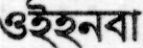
ওইহনবা
